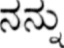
ನನ್ನು
